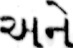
અને
